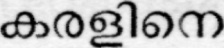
കരളിനെ
